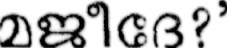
മജീദേ?’
